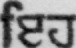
ਇਹ
